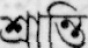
শ্রান্তি
